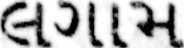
લગામ
